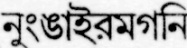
নুংঙাইরমগনি
